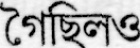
গৈছিলও
